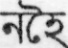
নহৈ
